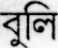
বুলি
